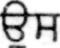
ਉਸ
